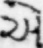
એ
